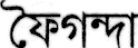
ফৈগন্দা
